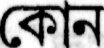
কোন
